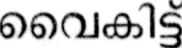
വൈകിട്ട്
